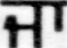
ਜਾ
